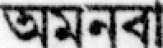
অমনবা
